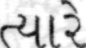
ત્યારે
